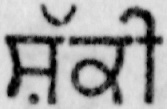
ਸ਼ੱਕੀ
